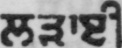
ਲੜਾਈ
